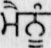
ਮੈਨੂੰ
